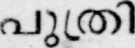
പുത്രി
